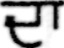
ਦਾ
